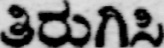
ತಿರುಗಿಸಿ
